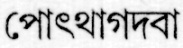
পোৎথাগদবা
